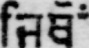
ਜਿਥੋਂ
